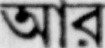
আর
